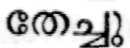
തേച്ചു
